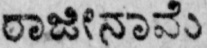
ರಾಜೀನಾಮೆ
